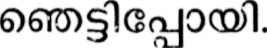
ഞെട്ടിപ്പോയി.
